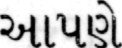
આપણે
